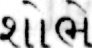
શોભે
